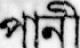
পানী
